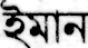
ইমান
